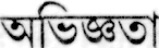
অভিজ্ঞতা
